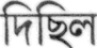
দিছিল
